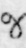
જ
